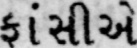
ફાંસીએ
